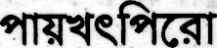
পায়খৎপিরো
